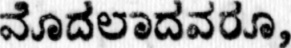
ಮೊದಲಾದವರೂ,
